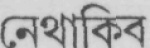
নেথাকিব
